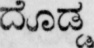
ದೊಡ್ಡ
